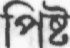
পিষ্ট
